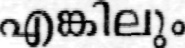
എങ്കിലും
